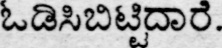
ಓಡಿಸಿಬಿಟ್ಟಿದಾರೆ.
